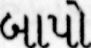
બાપો
